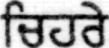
ਚਿਹਰੇ
